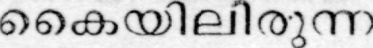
കൈയിലിരുന്ന
